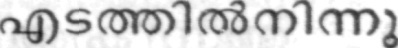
എടത്തില്‍നിന്നു
